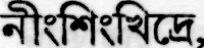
নীংশিংখিদ্রে,
